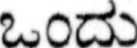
ಒಂದು
